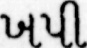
ખપી
